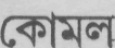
কোমল
